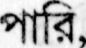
পারি,
